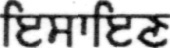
ਇਸਾਇਣ
